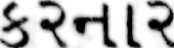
કરનાર
